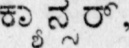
ಕ್ಯಾನ್ಸರ್,
